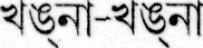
খঙনা-খঙনা
